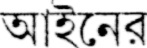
আইনের
